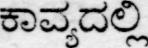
ಕಾವ್ಯದಲ್ಲಿ
